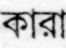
কারা
